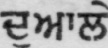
ਦੁਆਲੇ
